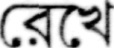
রেখে
